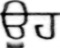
ਉਹ
